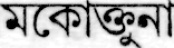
মকোক্তুনা
